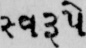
સ્વરૂપે
